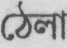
ঠেলা
